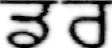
ਡਰ
